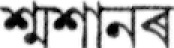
শ্মশানৰ
